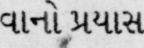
વાનોપ્રયાસ
